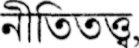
নীতিতত্ত্ব,
